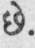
છે.
